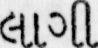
લાગી
